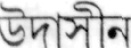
উদাসীন
